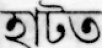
হাটত
